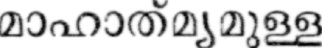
മാഹാത്മ്യമുള്ള
